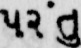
પરંતુ
